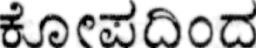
ಕೋಪದಿಂದ
